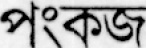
পংকজ
